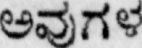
ಅವುಗಳ
